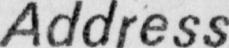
Address
